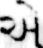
એ
